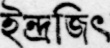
ইন্দ্রজিৎ
